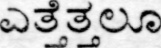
ಎತ್ತೆತ್ತಲೂ
